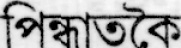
পিন্ধাতকৈ
